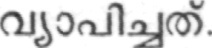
വ്യാപിച്ചത്.
